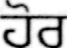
ਹੋਰ
